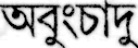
অবুংচাদু
